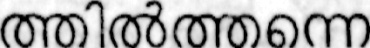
ത്തില്‍ത്തന്നെ
